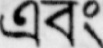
এবং
